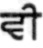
ਵੀ
